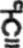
ਨੂੰ
